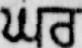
ਘਰ
